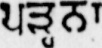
ਪੜ੍ਹਨਾ
